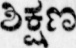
ಶಿಕ್ಷಣ
